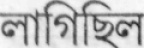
লাগিছিল
